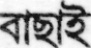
বাছাই
